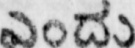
ಎಂದು
